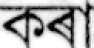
কৰা
